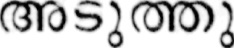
അടുത്തു
